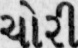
ચોરી
